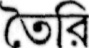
তৈরী
